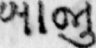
બાજુ
